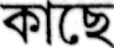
কাছে
